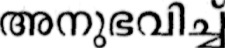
അനുഭവിച്ച്
